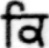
ਕਿ
